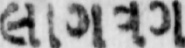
લાગવગ
